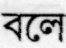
বলে
